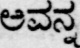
ಅವನ್ನ
